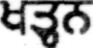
ਖੜ੍ਹਨ
